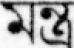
মন্ত্র
